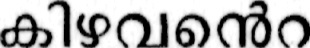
കിഴവന്റെ
